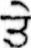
ਤੇ
